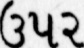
ઉપર
